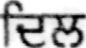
ਦਿਲ
